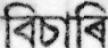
বিচাৰি
